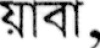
য়াবা,
